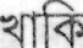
খাকি
